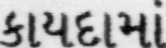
કાયદામાં
